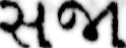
સજા
